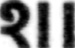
શા
